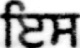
ਇਸ
